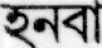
হনবা
